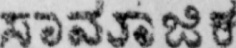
ಸಾಮಾಜಿಕ
